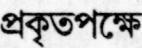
প্রকৃতপক্ষে
